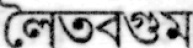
লৈতবগুম
